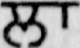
ਲਾ
